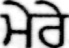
ਮੇਰੇ
